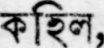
কহিল,
